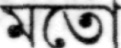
মতো
